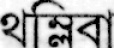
থম্লিবা
